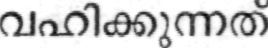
വഹിക്കുന്നത്
